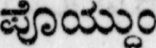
ಪೊಯ್ದುಂ
